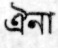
ঐনা
